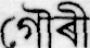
গৌৰী
